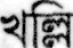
খল্লি
